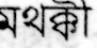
মথক্কী
